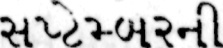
સપ્ટેમ્બરની
